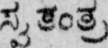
ಸ್ವತಂತ್ರ
